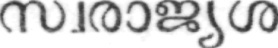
സ്വരാജ്യശ
